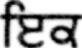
ਇਕ
